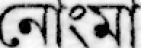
নোংমা
